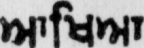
ਆਖਿਆ
